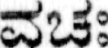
ವಚಃ
